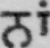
ਨਾਂ
